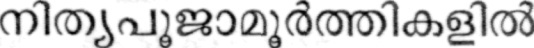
നിത്യപൂജാമൂര്‍ത്തികളില്‍
